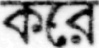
করে
